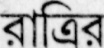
রাত্রির
